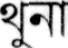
থুনা
